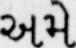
અમે
